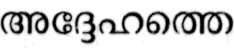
അദ്ദേഹത്തെ
